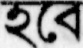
হবে
